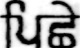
ਪਿਛੇ
